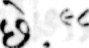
છે.૯૮
